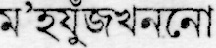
ম'হযুঁজখননো
